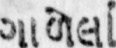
ગાળેલાં
